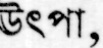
ঊৎপা,
